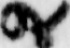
જ
